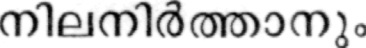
നിലനിര്‍ത്താനും
